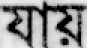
যায়
